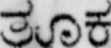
ತೂಕ
